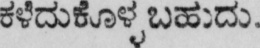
ಕಳೆದುಕೊಳ್ಳಬಹುದು.
